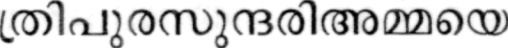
ത്രിപുരസുന്ദരിഅമ്മയെ
